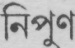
নিপুণ
